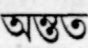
অন্তত
